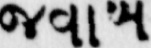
જવાબ
